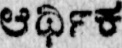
ಆರ್ಥಿಕ
